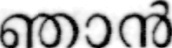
ഞാന്‍
